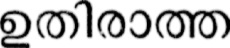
ഉതിരാത്ത
